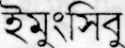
ইমুংসিবু
